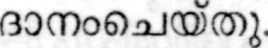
ദാനംചെയ്തു.
